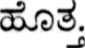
ಹೊತ್ತ.
